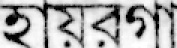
হায়রগা
